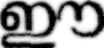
ഈ
